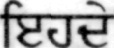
ਇਹਦੇ
